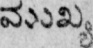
ಮುಖ್ಯ
